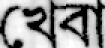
খেবা
